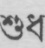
শুধ
